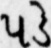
પડે
